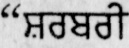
''ਸ਼ਰਬਰੀ
